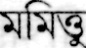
মমিত্তু
